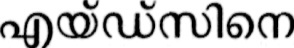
എയ്ഡ്സിനെ
